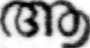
ആ
